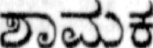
ಶಾಮಕ
